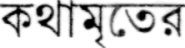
কথামৃতের
